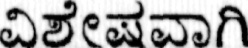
ವಿಶೇಷವಾಗಿ
